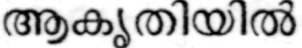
ആകൃതിയില്‍
